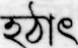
হঠাৎ
